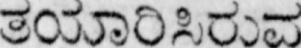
ತಯಾರಿಸಿರುವ
